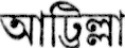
আট্টিল্লা
